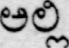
ಅಲ್ಲಿ
